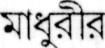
মাধুরীর
